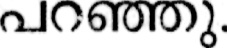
പറഞ്ഞു.
